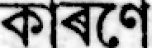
কাৰণে
